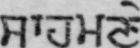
ਸਾਹਮਣੇ
